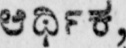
ಆರ್ಥಿಕ,
